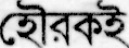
হৌরকই
